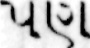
પણ
